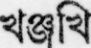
খঞ্জখি
